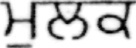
ਮੁਲਕ
